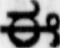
ಈ
